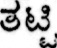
ತಟ್ಟಿ
